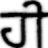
ਹੀ
